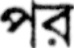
পর
